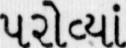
પરોવ્યાં
